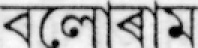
বলোৰাম
